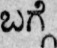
ಬಗ್ಗೆ
